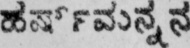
ಹರ್ಷಮನ್ನನ
